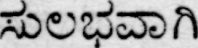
ಸುಲಭವಾಗಿ
